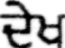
ਦੇਖ
